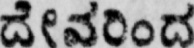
ದೇವರಿಂದ
